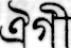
ঐগী
